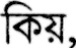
কিয়,
